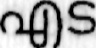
എട
